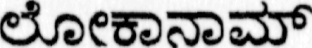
ಲೋಕಾನಾಮ್
